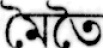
মৈতৈ
